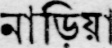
নাড়িয়া
